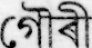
গৌৰী
